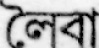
লৈবা
